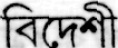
বিদেশী
